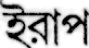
ইরাপ
